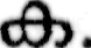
ക.
